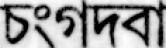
চংগদবা
